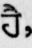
ਹੈ,
